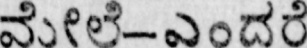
ಮೇಲೆ-ಎಂದರೆ
